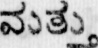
ಮತ್ತು
